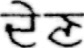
ਦੇਣ
